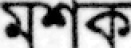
মশক
